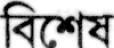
বিশেষ
